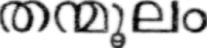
തന്മൂലം
